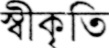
স্বীকৃতি
